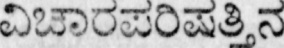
ವಿಚಾರಪರಿಷತ್ತಿನ
